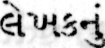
લેખકનું
